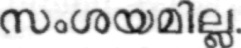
സംശയമില്ല.
